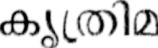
കൃത്രിമ
